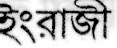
ইংরাজী
